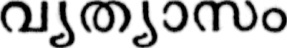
വ്യത്യാസം
